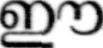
ഈ
